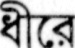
ধীরে
